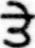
ਤੇ
